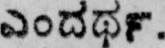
ಎಂದರ್ಥ.
